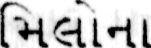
મિલોના
